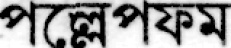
পল্লেপফম
